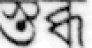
স্তব্ধ
